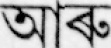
আৰু
